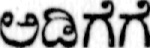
ಅಡಿಗೆಗೆ
